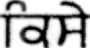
ਕਿਸੇ
